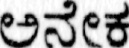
ಅನೇಕ
